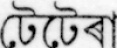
টেটেৰা
